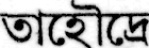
তাহৌদ্রে
